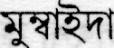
মুম্বাইদা
